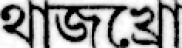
থাজখ্রো
